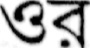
ওর
